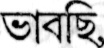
ভাবছি,
